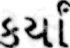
કર્યાં
